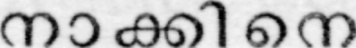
നാക്കിനെ
